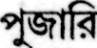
পুজারি
